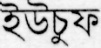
ইউচুফ
